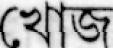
খোজ
